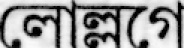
লোল্লগে
